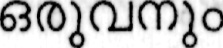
ഒരുവനും
